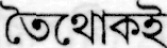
তৈথোকই
